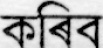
কৰিব
